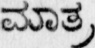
ಮಾತ್ರ
